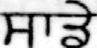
ਸਾਡੇ
